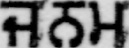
ਜਨਮ
